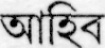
আহিব
